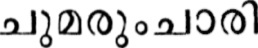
ചുമരുംചാരി
